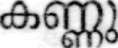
കണ്ണു
